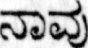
ನಾವು
